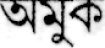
অমুক
